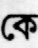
কে
